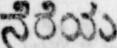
ನೆರೆಯ
